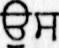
ਉਸ
